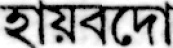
হায়বদো
